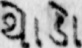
થોડો
